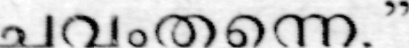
ചവംതന്നെ."
